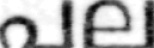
പല
